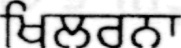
ਖਿਲਰਨਾ
